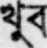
খুব
